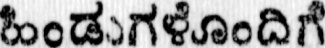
ಹಿಂಡುಗಳೊಂದಿಗೆ
